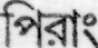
পিরাং
